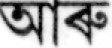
আৰু
